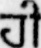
ਹੀ
